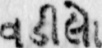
વડીલો
